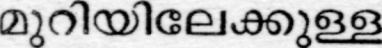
മുറിയിലേക്കുള്ള
